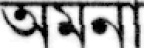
অমনা
